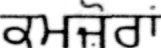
ਕਮਜ਼ੋਰਾਂ
